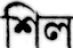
শিল
